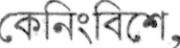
কেনিংবিশে,
